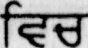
ਵਿਚ
